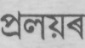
প্ৰলয়ৰ
